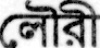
লৌরী
